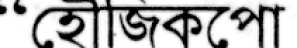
“হৌজিকপো
